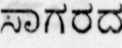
ಸಾಗರದ
